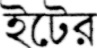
ইটের
